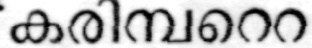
‘കരിമ്പറെറ
